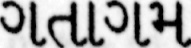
ગતાગમ
